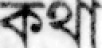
কথা
